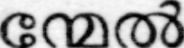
ന്മേല്‍
